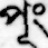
পূং
